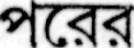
পরের
